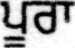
ਪੂਰਾ
